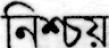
নিশ্চয়
